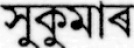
সুকুমাৰ
